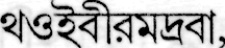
থওইবীরমদ্রবা,
